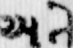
અને
